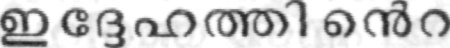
ഇദ്ദേഹത്തിന്റെ
